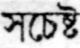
সচেষ্ট
